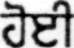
ਹੋਈ
